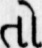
તો
